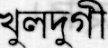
খুলদুগী
